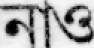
নাও
